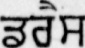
ਡਰੈਸ
